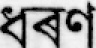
ধৰণ
